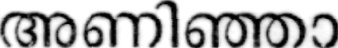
അണിഞ്ഞാ
